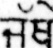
ਜੱਥੇ
